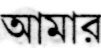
আমার
